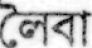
লৈবা
